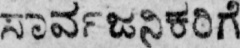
ಸಾರ್ವಜನಿಕರಿಗೆ
